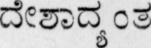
ದೇಶಾದ್ಯಂತ
